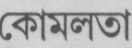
কোমলতা
